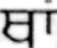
ਥਾਂ
